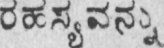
ರಹಸ್ಯವನ್ನು
